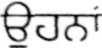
ਉਹਨਾਂ
